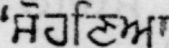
'ਸੋਹਣਿਆ
